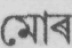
মোৰ
